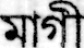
মাগী
